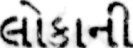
લોકાની
